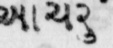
આચરું
